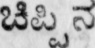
ಚಿಪ್ಪಿನ
